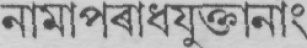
নামাপৰাধযুক্তানাং
